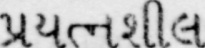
પ્રયત્નશીલ
